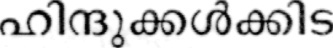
ഹിന്ദുക്കള്‍ക്കിട
